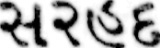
સરહદ
